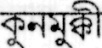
কুনমুক্কী
